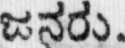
ಜನರು.
